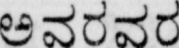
ಅವರವರ
